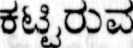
ಕಟ್ಟಿರುವ
